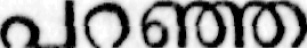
പറഞ്ഞ
